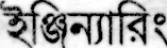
ইঞ্জিন্যারিং
